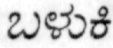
ಬಳುಕಿ
